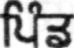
ਪਿੰਡ
